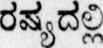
ರಷ್ಯದಲ್ಲಿ
